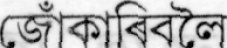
জোঁকাৰিবলৈ
